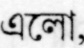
এলো,
